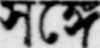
সঙ্গে
